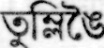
তুম্লিঙৈ
